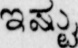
ಇಷ್ಟು
